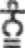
ਨੂੰ
